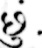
છું.
